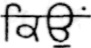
ਕਿਉਂ
